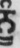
ਨੂੰ
